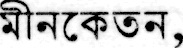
মীনকেতন,
